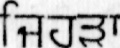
ਜਿਹੜਾ
